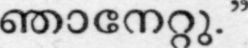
ഞാനേറ്റു."
